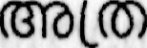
അത്ര
